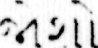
જોશો
